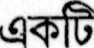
একটি
